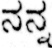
ನನ್ನ
